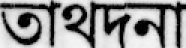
তাথদনা
